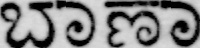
ಬಾಣಾ
